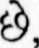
છે,
